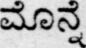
ಮೊನ್ನೆ
